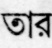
তার
